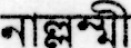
নাল্লম্মী
